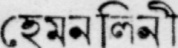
হেমনলিনী
